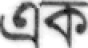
এক
